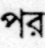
পর
